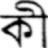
কী
